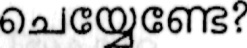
ചെയ്യേണ്ടേ?
